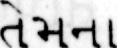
તેમના
